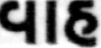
વાહ
